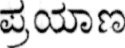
ಪ್ರಯಾಣ
